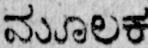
ಮೂಲಕ
